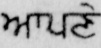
ਆਪਣੇ
